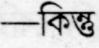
–কিন্তু
